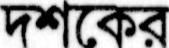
দশকের
